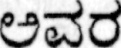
ಅವರ
